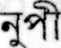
নুপী
